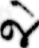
જે
